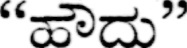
"ಹೌದು"
